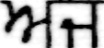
ਅਜ
